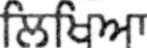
ਲਿਖਿਆ
